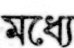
মধ্যে
